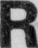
R
